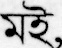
মই,
